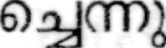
ച്ചെന്നു
